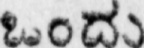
ಒಂದು
